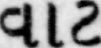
વાટ
